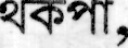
থকপা,
